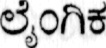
ಲೈಂಗಿಕ
